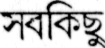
সবকিছু
